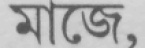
মাজে,
